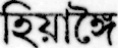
হিয়াঙ্গৈ
